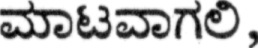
ಮಾಟವಾಗಲಿ,
